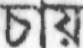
চায়
